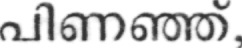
പിണഞ്ഞ്,
